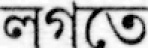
লগতে
